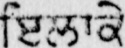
ਇਲਾਕੇ
